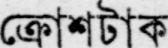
ক্রোশটাক
